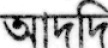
আদদি
